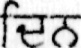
ਦਿਨ
